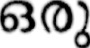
ഒരു
